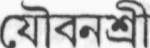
যৌবনশ্রী
